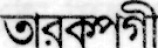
তারকপগী
